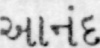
આનંદ
